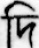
দি
